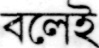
বলেই
